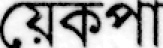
য়েকপা
